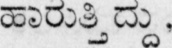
ಹಾರುತ್ತಿದ್ದು,
